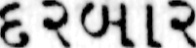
દરબાર
